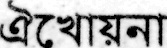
ঐখোয়না
